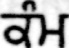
ਕੰਮ
